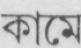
কামে
